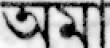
অমা
